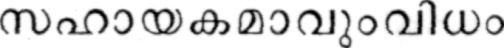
സഹായകമാവുംവിധം
